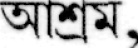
আশ্রম,
